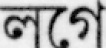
লগে
